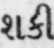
શકી
